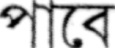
পাবে
